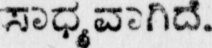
ಸಾಧ್ಯವಾಗಿದೆ.
